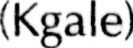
(Kgale)
